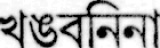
খঙবনিনা
